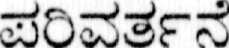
ಪರಿವರ್ತನೆ
